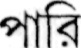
পারি
